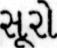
સૂરો
